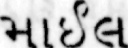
માઈલ
